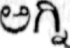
ಅಗ್ನಿ
